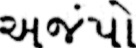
અજંપો
